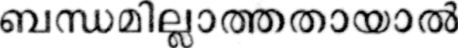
ബന്ധമില്ലാത്തതായാല്‍
